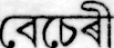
বেচেৰী
